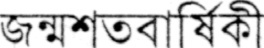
জন্মশতবার্ষিকী
